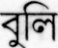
বুলি
